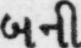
બની
